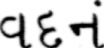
વદનં
